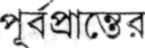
পূর্বপ্রান্তের
